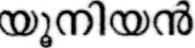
യൂനിയന്‍
